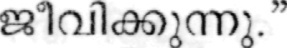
ജീവിക്കുന്നു."
